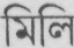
মিলি
